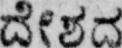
ದೇಶದ
